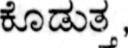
ಕೊಡುತ್ತ,
